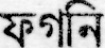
ফগনি
